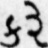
કરે
